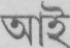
আই
